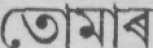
তোমাৰ
